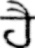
ਹੈ
